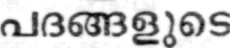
പദങ്ങളുടെ
